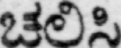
ಚಲಿಸಿ
